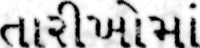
તારીખોમાં
